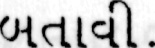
બતાવી.
